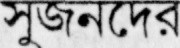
সুজনদের
